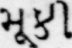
મૂકી
